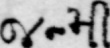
જન્મી
